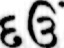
દઉં
